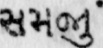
સમજું
